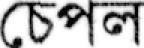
চেপল
